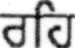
ਰਹਿ
